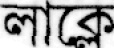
লাক্লে
